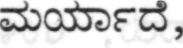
ಮರ್ಯಾದೆ,
